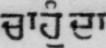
ਚਾਹੁੰਦਾ
